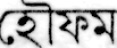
হৌফম
